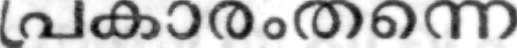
പ്രകാരംതന്നെ
